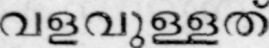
വളവുള്ളത്
